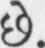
છે.
